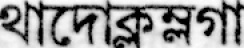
থাদোক্লম্লগা
